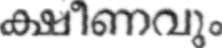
ക്ഷീണവും
